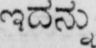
ಇದನ್ನು
